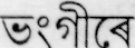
ভংগীৰে
